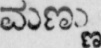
ಮಣ್ಣು
